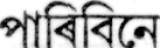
পাৰিবিনে
